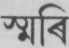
স্মৰি
